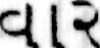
વાર
